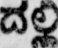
ದಲ್ಲಿ
